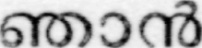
ഞാന്‍
